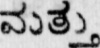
ಮತ್ತು
